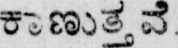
ಕಾಣುತ್ತವೆ.
